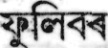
ফুলিবৰ
